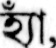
হ্যাঁ,
